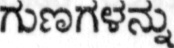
ಗುಣಗಳನ್ನು
